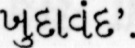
ખુદાવંદ'.
